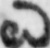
ಎ
